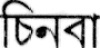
চিনবা
